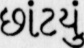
છાંટયું
